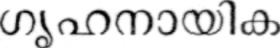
ഗൃഹനായിക
